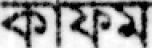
কাফম
